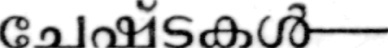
ചേഷ്ടകള്‍-
